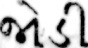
જોડી
